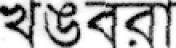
খঙবরা
